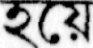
হয়ে
